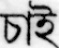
চাই
